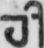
ਹੀ
